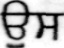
ਉਸ
